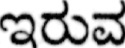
ಇರುವ
